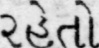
રહેતો
